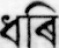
ধৰি
